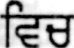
ਵਿਚ
